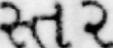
સ્તર
